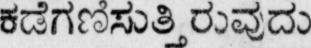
ಕಡೆಗಣಿಸುತ್ತಿರುವುದು
